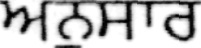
ਅਨੁਸਾਰ
